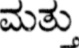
ಮತ್ತು
